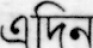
এদিন
